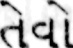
તેવો
